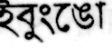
ইবুংঙো
